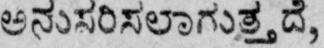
ಅನುಸರಿಸಲಾಗುತ್ತದೆ,
